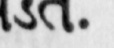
પડત.
